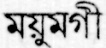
ময়ুমগী
